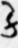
કે
